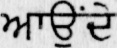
ਆਉਂਦੇ
